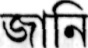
জানি
